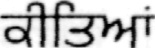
ਕੀਤਿਆ
